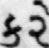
કરે
